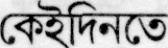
কেইদিনতে
